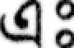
এঃ
